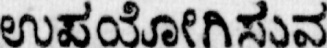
ಉಪಯೋಗಿಸುವ
